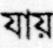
যায়
